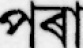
পৰা
